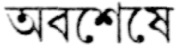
অবশেষে
